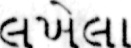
લખેલા
